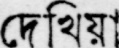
দেখিয়া
